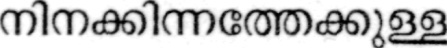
നിനക്കിന്നത്തേക്കുള്ള
